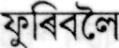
ফুৰিবলৈ
